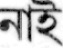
নাই
